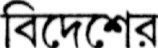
বিদেশের
